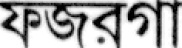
ফজরগা
